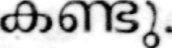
കണ്ടു.
